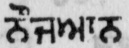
ਨੌਜੁਆਨ
